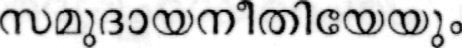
സമുദായനീതിയേയും
